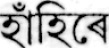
হাঁহিৰে
